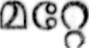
മറ്റേ
